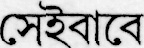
সেইবাবে
